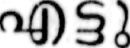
എട്ടു
